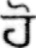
ਹੋ
